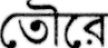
তৌরে
